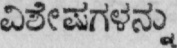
ವಿಶೇಷಗಳನ್ನು
